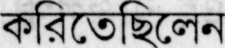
করিতেছিলেন
